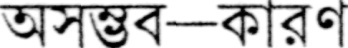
অসম্ভব–কারণ
